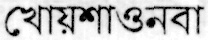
খোয়শাওনবা
